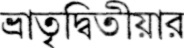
ভ্রাতৃদ্বিতীয়ার
